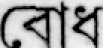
বোধ
